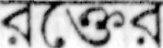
রক্তের
